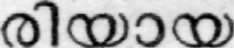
രിയായ
